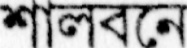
শালবনে
